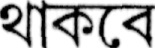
থাকবে
